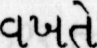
વખતે
